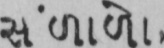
સંળાળો.
